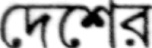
দেশের
